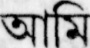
আমি
